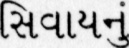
સિવાયનું
